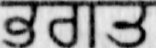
ਭਗਤ
